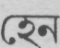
হেন
